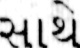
સાથે
